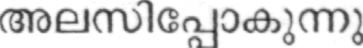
അലസിപ്പോകുന്നു
